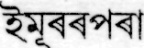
ইমূৰৰপৰা
